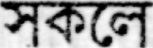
সকলে
